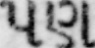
પણ
